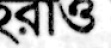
হরাও
